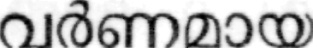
വര്‍ണമായ
